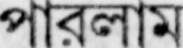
পারলাম
